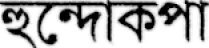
হুন্দোকপা
